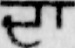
ਦਾ
